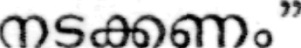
നടക്കണം”
